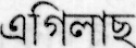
এগিলাছ
